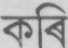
কৰি
